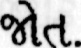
જોત.
